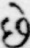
છે
